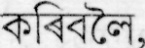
কৰিবলৈ,
